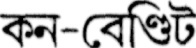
কন-বেণ্ডিট
